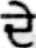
ਦੇ
